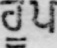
ਹੂਪ
